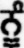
ਨੂੰ
